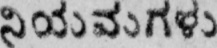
ನಿಯಮಗಳು
